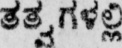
ತತ್ವಗಳಲ್ಲಿ
